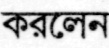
করলেন
